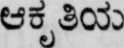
ಆಕೃತಿಯ
